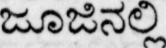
ಜೂಜಿನಲ್ಲಿ
